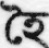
হৈ
